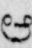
ಆ
